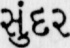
સુંદર
